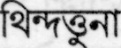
থিন্দত্তুনা
